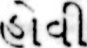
હોવી
